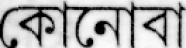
কোনোবা
